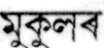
মুকুলৰ
